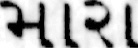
મારા
